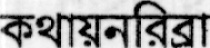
কথায়নরিব্রা
